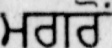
ਮਗਰੋਂ
